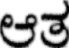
ಆತ
